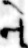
ને
